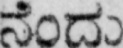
ನೆಂದು
